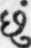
છું
